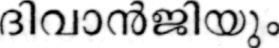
ദിവാന്‍ജിയും
